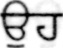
ਉਹ
